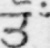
ਤੋਂ
